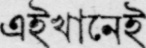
এইখানেই
